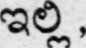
ಇಲ್ಲಿ,
